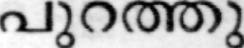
പുറത്തു
